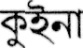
কুইনা
